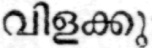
വിളക്കു
